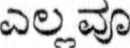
ಎಲ್ಲವೂ
